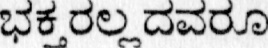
ಭಕ್ತರಲ್ಲದವರೂ
